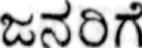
ಜನರಿಗೆ
